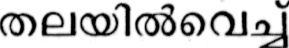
തലയില്‍വെച്ച്
